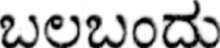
ಬಲಬಂದು
